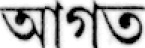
আগত
